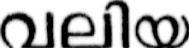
വലിയ
